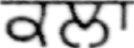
ਕਲਾ
